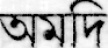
অমদি
